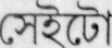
সেইটো
